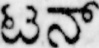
ಟನ್
